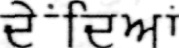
ਦੇਂਦਿਆ
